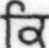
ਕਿ
